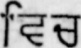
ਵਿਚ
